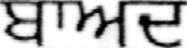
ਬਾਅਦ
